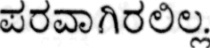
ಪರವಾಗಿರಲಿಲ್ಲ.
